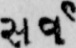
સર્વ
